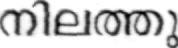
നിലത്തു
